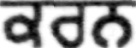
ਕਰਨ
